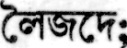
লৈজদে;
